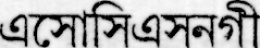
এসোসিএসনগী
